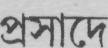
প্ৰসাদে
